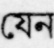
যেন
